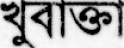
খুবাক্তা
